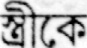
স্ত্রীকে
